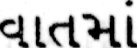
વાતમાં
